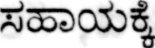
ಸಹಾಯಕ್ಕೆ
